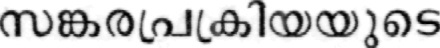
സങ്കരപ്രക്രിയയുടെ
